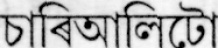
চাৰিআলিটো
